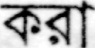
করা
